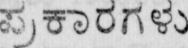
ಪ್ರಕಾರಗಳು
